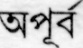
অপূর্ব
